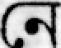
নে
